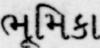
ભૂમિકા
